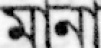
মানা
